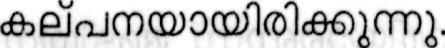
കല്പനയായിരിക്കുന്നു.
